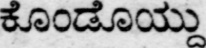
ಕೊಂಡೊಯ್ದು
